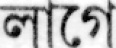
লাগে
